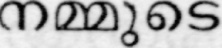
നമ്മുടെ
